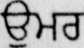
ਉਮਰ
